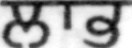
ਲਾਭ
